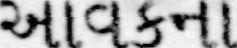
આવકના
